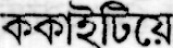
ককাইটিয়ে
